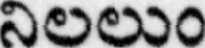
ನಿಲಲುಂ
